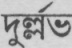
দুৰ্ল্লভ
